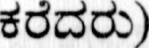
ಕರೆದರು)
